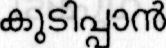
കുടിപ്പാന്‍
